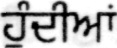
ਹੁੰਦੀਆਂ
